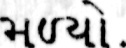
મળ્યો.
